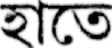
হাতে
